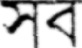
সব
